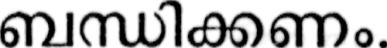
ബന്ധിക്കണം.
